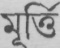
মূৰ্ত্তি
